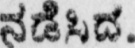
ನಡೆಸಿದ.
